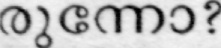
രുന്നോ?
